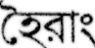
হৈরাং
